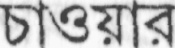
চাওয়ার
